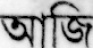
আজি
